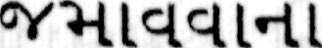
જમાવવાના
